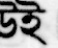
উই
